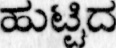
ಹುಟ್ಟಿದ
